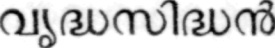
വൃദ്ധസിദ്ധന്‍
